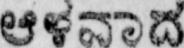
ಆಳವಾದ
